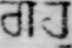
ਗਹੁ
